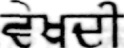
ਵੇਖਦੀ
